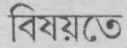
বিষয়তে
